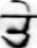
ਤੇ
